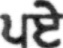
ਪਏ
